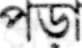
পড়া
